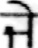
ਜੇ
